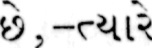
છે,-ત્યારે
